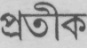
প্রতীক
